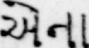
એના
